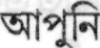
আপুনি
